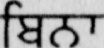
ਬਿਨਾ
